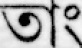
তাং
